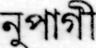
নুপাগী
